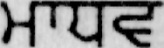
ਮਾਧਵ
